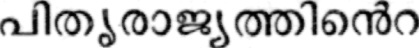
പിതൃരാജ്യത്തിന്റെ
